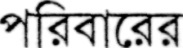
পরিবারের
